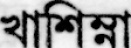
খাশিম্না
